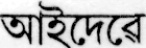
আইদেৱে
